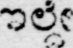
ಇಲ್ದೇ
